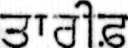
ਤਾਰੀਫ਼
